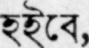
হইবে,
